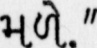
મળે."
